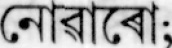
নোৱাৰো;
